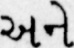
અને
